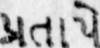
પ્રતાપે
